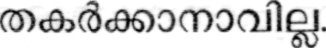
തകര്‍ക്കാനാവില്ല.
